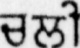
ਚਲੀ
